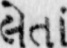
લેતાં
